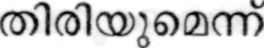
തിരിയുമെന്ന്
